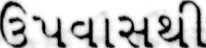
ઉપવાસથી
